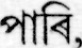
পাৰি,
